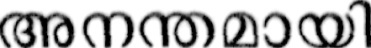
അനന്തമായി
